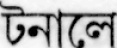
টনালে
